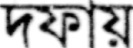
দফায়
